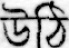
উঠি
